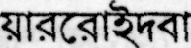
য়াররোইদবা
